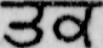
ਤਕ
